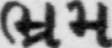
ભ્રમ
